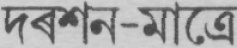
দৰশন-মাত্ৰে
